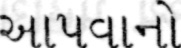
આપવાનો
